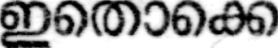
ഇതൊക്കെ
